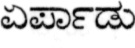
ಏರ್ಪಾಡು
